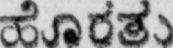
ಹೊರತು
